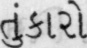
તુંકારો
